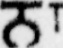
ਨਾ
